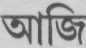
আজি
